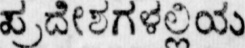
ಪ್ರದೇಶಗಳಲ್ಲಿಯ
